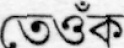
তেওঁক
